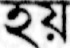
হয়
